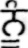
ਨੂੰ
